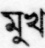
মুখ
